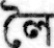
লৈ
